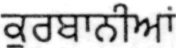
ਕੁਰਬਾਨੀਆਂ
